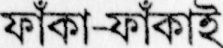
ফাঁকা-ফাঁকাই
